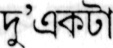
দু'একটা
